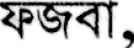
ফজবা,
